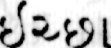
ઇચ્છા
